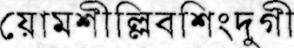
য়োমশীল্লিবশিংদুগী
